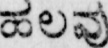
ಹಲವು
